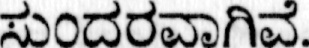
ಸುಂದರವಾಗಿವೆ.
